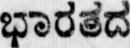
ಭಾರತದ
